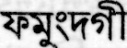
ফমুংদগী
